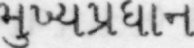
મુખ્યપ્રધાન
